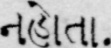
નહોતા.
